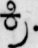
ಕ್ರಿ.
